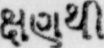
ક્ષણથી
